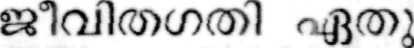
ജീവിതഗതിഏതു
